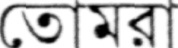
তোমরা
